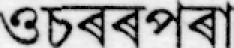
ওচৰৰপৰা
